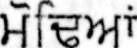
ਮੋਢਿਆਂ
